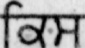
ਕਿਸ
